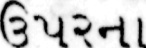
ઉપરના
